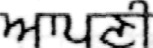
ਆਪਣੀ
